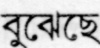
বুঝেছে
